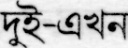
দুই-এখন
